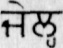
ਜੇਲ੍ਹ
